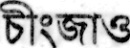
চীংজাও
